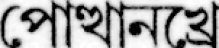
পোত্থানখ্রে
